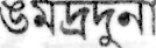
ঙমদ্রদুনা
